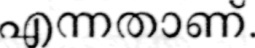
എന്നതാണ്.
